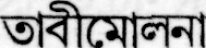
তাবীমোলনা
